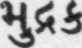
મુદ્રક
